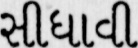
સીધાવી
